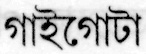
গাইগোটা
